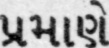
પ્રમાણે
